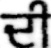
ਦੀ
